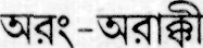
অরং-অরাক্কী
